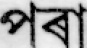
পৰা
